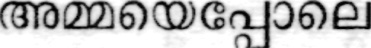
അമ്മയെപ്പോലെ
